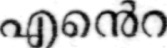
എന്റെ
